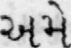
અમે
